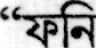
“ফনি
